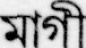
মাগী
